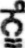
ਨੂੰ
